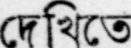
দেখিতে
